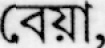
বেয়া,
